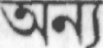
অন্য
